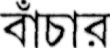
বাঁচার
